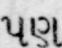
પણ
